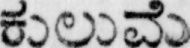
ಕುಲುಮೆ
